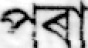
পৰা
